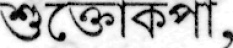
শুক্তোকপা,
